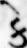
કે
